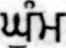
ਘੁੰਮ
